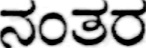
ನಂತರ
